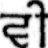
ਵੀ
